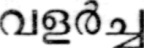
വളര്‍ച്ച
